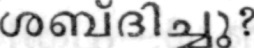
ശബ്ദിച്ചു?
